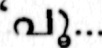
‘പൂ…
